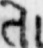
તો
